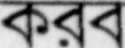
করব
